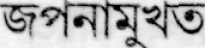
জপনামুখত
